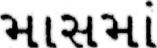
માસમાં
